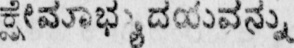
ಕ್ಷೇಮಾಭ್ಯುದಯವನ್ನು
